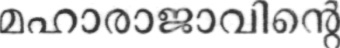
മഹാരാജാവിന്റെ
